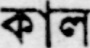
কাল
